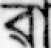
ৱা
